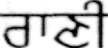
ਰਾਣੀ
